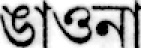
ঙাওনা
